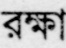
রক্ষা
